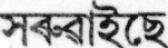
সৰুৱাইছে
